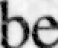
be
